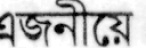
এজনীয়ে
